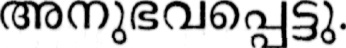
അനുഭവപ്പെട്ടു.
